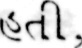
હતી,
